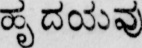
ಹೃದಯವು
